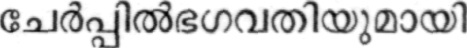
ചേര്‍പ്പില്‍ഭഗവതിയുമായി
